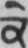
ਕੇ
